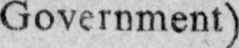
Government)
